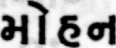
મોહન
